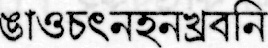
ঙাওচৎনহনখ্রবনি
